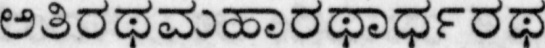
ಅತಿರಥಮಹಾರಥಾರ್ಧರಥ
